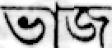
ভাজ
